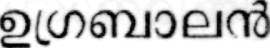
ഉഗ്രബാലന്‍
